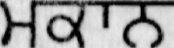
ਮਕਾਨ
